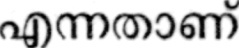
എന്നതാണ്
